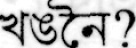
খঙনৈ?
